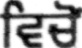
ਵਿਚੋਂ
